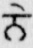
ਨੇ
